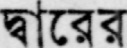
দ্বারের
